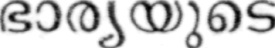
ഭാര്യയുടെ
